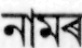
নামৰ
